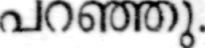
പറഞ്ഞു.
